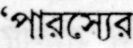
‘পারস্যের
